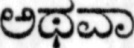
ಅಥವಾ
